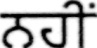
ਨਹੀਂ
